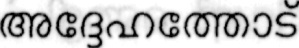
അദ്ദേഹത്തോട്
